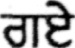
ਗਏ
